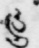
હું
